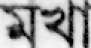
মখা
